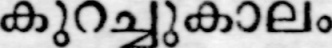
കുറച്ചുകാലം
